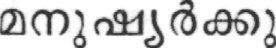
മനുഷ്യര്‍ക്കു
